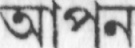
আপন
